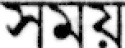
সময়
